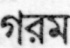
গরম
